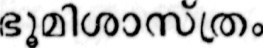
ഭൂമിശാസ്ത്രം
